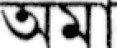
অমা
